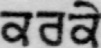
ਕਰਕੇ
